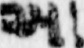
આ
